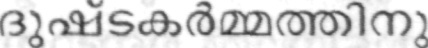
ദുഷ്ടകര്‍മ്മത്തിനു
